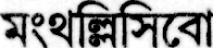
মংথল্লিসিবো
